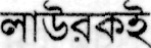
লাউরকই
